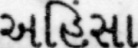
અહિંસા
